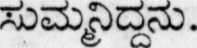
ಸುಮ್ಮನಿದ್ದನು.
